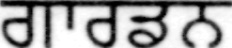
ਗਾਰਡਨ
